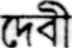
দেবী
